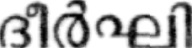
ദീര്‍ഘി
